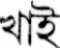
খাই
